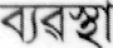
ব্যৱস্থা
